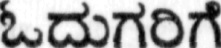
ಓದುಗರಿಗೆ
